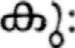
കു:
